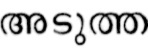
അടുത്ത
